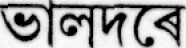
ভালদৰে
